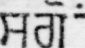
ਸਗੋਂ
